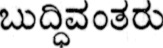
ಬುದ್ಧಿವಂತರು
